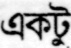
একটু
